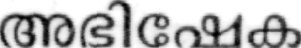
അഭിഷേക
